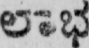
ಲಾಭ
